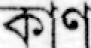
কাণ
